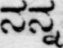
ನನ್ನ
